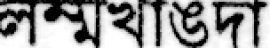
লম্মখাঙদা
